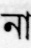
না
